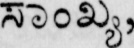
ಸಾಂಖ್ಯ,
